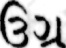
ઉગ્ર
